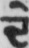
ਦੇ
